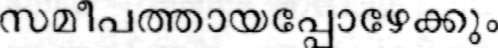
സമീപത്തായപ്പോഴേക്കും
